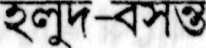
হলুদ-বসন্ত
